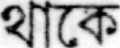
থাকে
